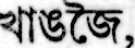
খাঙজৈ,
